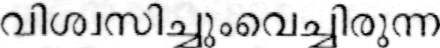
വിശ്വസിച്ചുംവെച്ചിരുന്ന
